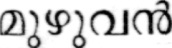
മുഴുവന്‍
